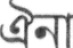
ঐনা
